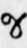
જ
